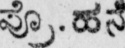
ಪ್ರೊ.ಹನೆ
